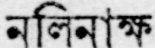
নলিনাক্ষ
